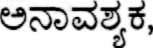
ಅನಾವಶ್ಯಕ,
